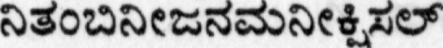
ನಿತಂಬಿನೀಜನಮನೀಕ್ಷಿಸಲ್
